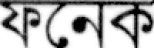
ফনেক
